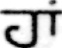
ਹਾਂ
